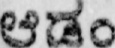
ಆಡಂ
